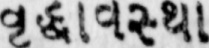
વૃદ્ધાવસ્થા
